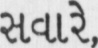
સવારે,
